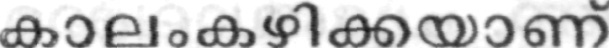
കാലംകഴിക്കയാണ്
